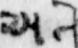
અને
